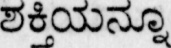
ಶಕ್ತಿಯನ್ನೂ
